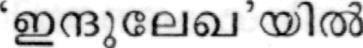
'ഇന്ദുലേഖ'യില്‍
